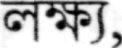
লক্ষ্য,
